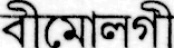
বীমোলগী
